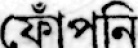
ফোঁপনি
